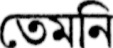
তেমনি
